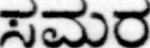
ಸಮರ
